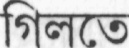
গিলতে
